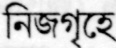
নিজগৃহে
